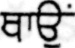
ਥਾਉਂ
